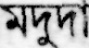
মদুদা
